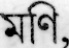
মণি,
